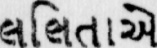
લલિતાએ
